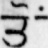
ਤੋਂ
